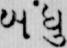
બંધુ
